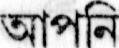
আপনি
